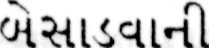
બેસાડવાની
